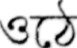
ওঠে
